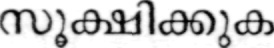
സൂക്ഷിക്കുക
